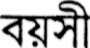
বয়সী
